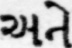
અને
